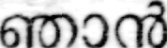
ഞാന്‍
